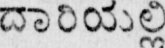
ದಾರಿಯಲ್ಲಿ
